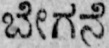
ಬೇಗನೆ
